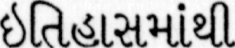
ઇતિહાસમાંથી
